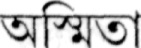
অস্মিতা
